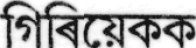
গিৰিয়েকক
